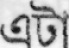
এটা
